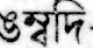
ঙম্বদি
